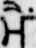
ਮੈਂ
